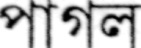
পাগল
